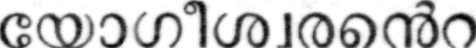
യോഗീശ്വരന്റെ
